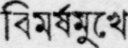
বিমর্ষমুখে
